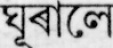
ঘূৰালে
